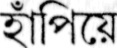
হাঁপিয়ে
